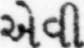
એવી
